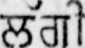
ਲੱਗੀ
